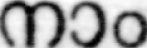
നാം
